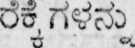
ರೆಕ್ಕೆಗಳನ್ನು
